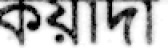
কয়াদা
